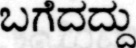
ಬಗೆದದ್ದು
